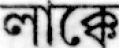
লাক্কে
